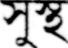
সুস্থ
